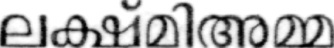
ലക്ഷ്മിഅമ്മ
